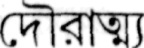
দৌরাত্ম্য
